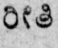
ರೀತಿ
